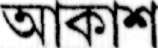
আকাশ
